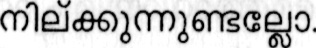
നില്ക്കുന്നുണ്ടല്ലോ.
